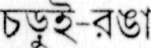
চড়ুই-রঙা
